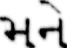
મને
